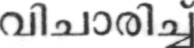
വിചാരിച്ച്
